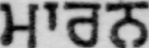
ਮਾਰਨ
